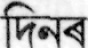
দিনৰ
